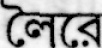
লৈরে
